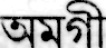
অমগী
